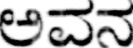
ಅವನ
